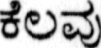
ಕೆಲವು
